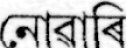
নোৱাৰি
